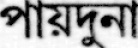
পায়দুনা
